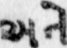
અને
